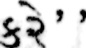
કરે"
